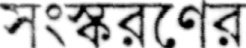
সংস্করণের
